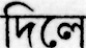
দিলে
